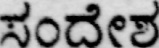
ಸ೦ದೇಶ
